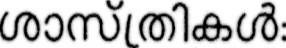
ശാസ്ത്രികള്‍:
